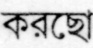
করছো
